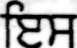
ਇਸ
